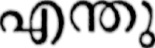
എന്തു
